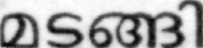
മടങ്ങി
